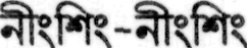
নীংশিং-নীংশিং
